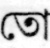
তো
